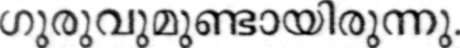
ഗുരുവുമുണ്ടായിരുന്നു.
